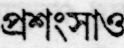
প্রশংসাও
